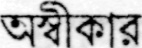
অস্বীকার
